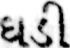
ઘડી
